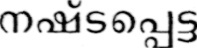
നഷ്ടപ്പെട്ട
